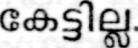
കേട്ടില്ല.
